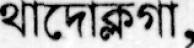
থাদোক্লগা,
